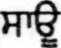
ਸਾਊ
